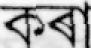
কৰা
